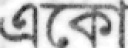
একো
